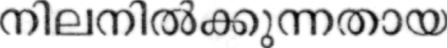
നിലനില്‍ക്കുന്നതായ
